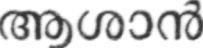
ആശാന്‍
